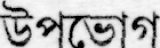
উপভোগ
